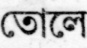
তোলে
